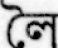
লৈ
